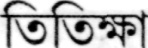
তিতিক্ষা
